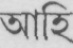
আহি
